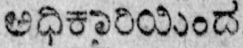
ಅಧಿಕಾರಿಯಿಂದ
